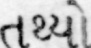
તથ્યો
